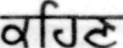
ਕਹਿਣ
